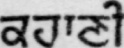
ਕਹਾਣੀ
